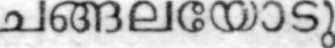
ചങ്ങലയോടു
